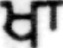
ਖਾ
